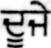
ਦੂਜੇ
